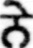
ਨੇ
